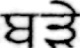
ਬੜੇ
